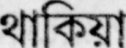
থাকিয়া
